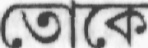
তোকে
